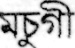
মচুগী
